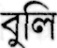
বুলি
